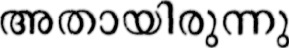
അതായിരുന്നു
